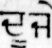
ਦੂਜੇ
